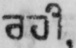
ਰਹੀ,
